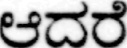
ಆದರೆ
